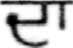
ਦਾ
